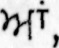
ਆਂ,
